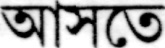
আসতে
